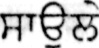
ਸਾਉਲੇ
